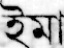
ইমা
